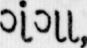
ગંગા,
